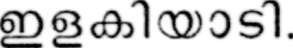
ഇളകിയാടി.
